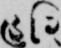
હરિ
